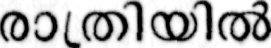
രാത്രിയില്‍
